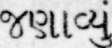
જણાવ્યું
